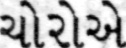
ચોરોએ
